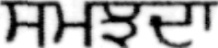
ਸਮਝਦਾ
